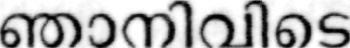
ഞാനിവിടെ
